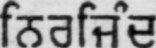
ਨਿਰਜਿੰਦ
